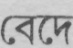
বেদে
